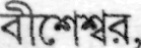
বীশেশ্বর,
